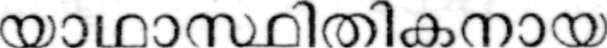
യാഥാസ്ഥിതികനായ
